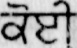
ਕੋਈ
